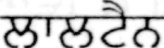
ਲਾਲਟੈਨ
